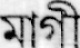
মাগী
